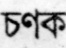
চণক
